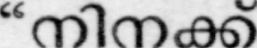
"നിനക്ക്
